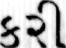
કરી
